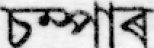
চম্পাৰ
